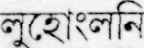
লুহোংলনি
